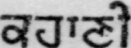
ਕਹਾਣੀ
